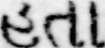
હતા
